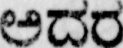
ಅದರ
